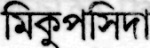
মিকুপসিদা
